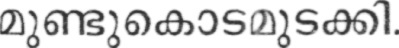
മുണ്ടുകൊടമുടക്കി.
